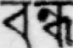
বন্ধ
